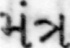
મંત્ર
